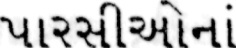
પારસીઓનાં
